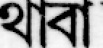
থাবা
